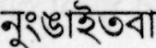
নুংঙাইতবা
